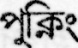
পুক্নিং
